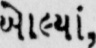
બોલ્યાં,
